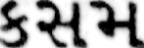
કસમ
